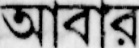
আবার
